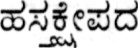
ಹಸ್ತಕ್ಷೇಪದ
